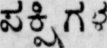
ಪಕ್ಷಿಗಳ
